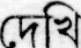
দেখি
